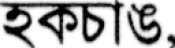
হকচাঙ,
